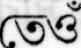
তেওঁ
